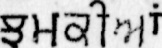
ਝਮਕੀਆਂ
